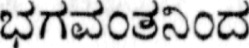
ಭಗವಂತನಿಂದ
